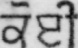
ਕੋਈ
